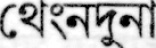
থেংনদুনা
